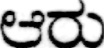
ಆರು
